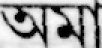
অমা
